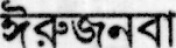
ঈরুজনবা
